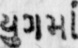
સ્વાતંત્ર્યનો
